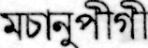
মচানুপীগী
